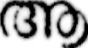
ആ
